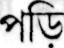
পড়ি
